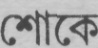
শোকে
